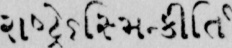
રાષ્ટ્રેઽસ્મિન્કીર્તિ
